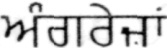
ਅੰਗਰੇਜ਼ਾਂ
